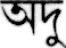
অদু
